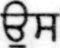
ਉਸ
